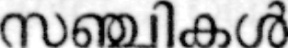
സഞ്ചികള്‍
